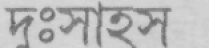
দুঃসাহস
